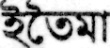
ইতৈমা
